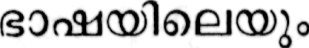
ഭാഷയിലെയും
